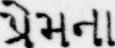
પ્રેમના
